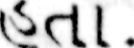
હતા.
